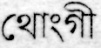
থোংগী
